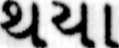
થયા
